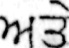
ਅਤੇ
